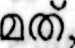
മത്,
